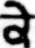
ਕੇ
